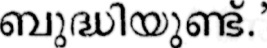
ബുദ്ധിയുണ്ട്.'
